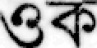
ওক
